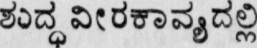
ಶುದ್ಧವೀರಕಾವ್ಯದಲ್ಲಿ
